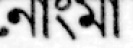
নোংমা
